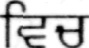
ਵਿਚ
